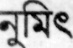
নুমিৎ
